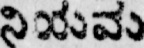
ನಿಯಮ
